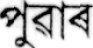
পুৱাৰ
